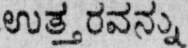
ಉತ್ತರವನ್ನು
